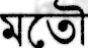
মতৌ
